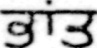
ਭਾਂਤ
